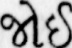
જોઈ
